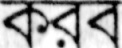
করব
